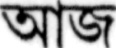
আজ
